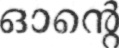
ഓന്റെ
